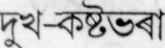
দুখ-কষ্টভৰা
